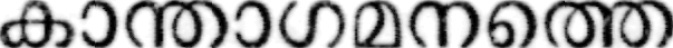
കാന്താഗമനത്തെ
